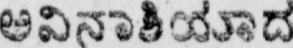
ಅವಿನಾಶಿಯಾದ
